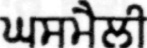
ਘਸਮੈਲੀ
